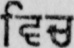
ਵਿਚ
